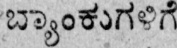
ಬ್ಯಾಂಕುಗಳಿಗೆ
